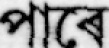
পাৰে
